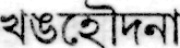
খঙহৌদনা
